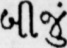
બીજું
